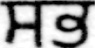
ਸਭ
